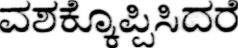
ವಶಕ್ಕೊಪ್ಪಿಸಿದರೆ
